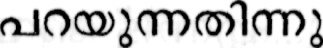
പറയുന്നതിന്നു
